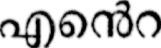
എന്റെ
